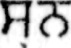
ਸਨ
